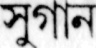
সুগান
